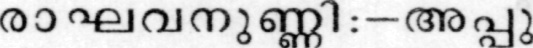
രാഘവനുണ്ണി:-അപ്പു
